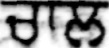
ਚਾਲ
